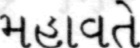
મહાવતે
